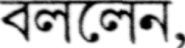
বললেন,
